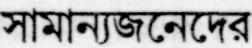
সামান্যজনেদের
